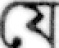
যে
